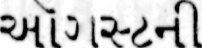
ઑગસ્ટની
